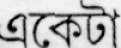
একেটা
